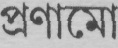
প্ৰণামো
